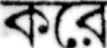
করে
